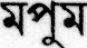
মপুম
